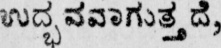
ಉದ್ಭವವಾಗುತ್ತದೆ,
